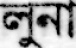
লুনা
